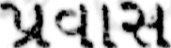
પ્રવાસ
